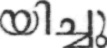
യിച്ചു
